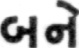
બને
